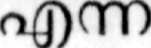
എന്ന
